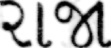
રાજા
